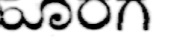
ಹೊರಗೆ
